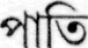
পাতি
